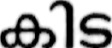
കിട
